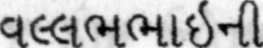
વલ્લભભાઈની
